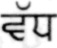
ਵੱਧ
